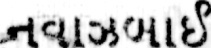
નવાઝબાઈ
